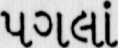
પગલાં
